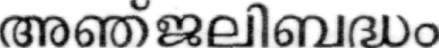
അഞ്ജലിബദ്ധം
